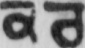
ਕਰ
